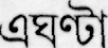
এঘণ্টা
